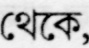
থেকে,
